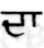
ਦਾ
